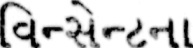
વિન્સેન્ટના
